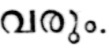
വരും.
